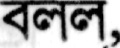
বলল,
